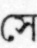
সে
